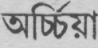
অৰ্চ্চিয়া
